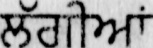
ਲੱਗੀਆਂ
